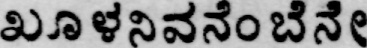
ಖೂಳನಿವನೆಂಬೆನೇ
